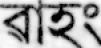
ৱাহং
